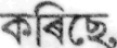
কৰিছে,
